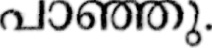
പാഞ്ഞു.
